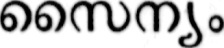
സൈന്യം
